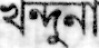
খন্দুনা
